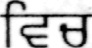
ਵਿਚ
